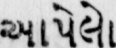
આપેલો
